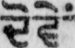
ਦੋਵੇਂ
